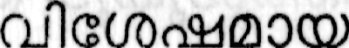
വിശേഷമായ
